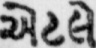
એટલે
